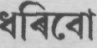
ধৰিবো
